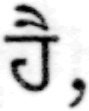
ਹੈ,
